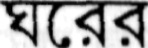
ঘরের
